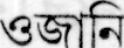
ওজানি
